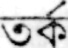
তর্ক
